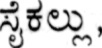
ಸೈಕಲ್ಲು,
